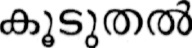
കൂടുതല്‍
